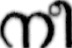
നീ
